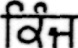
ਕਿੰਜ
